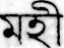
মহী
